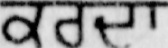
ਕਰਦਾ
